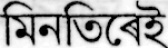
মিনতিৰেই
